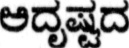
ಅದೃಷ್ಟದ
